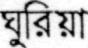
ঘুরিয়া
